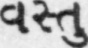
વસ્તુ
